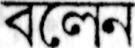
বলেন
